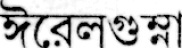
ঈরেলগুম্না
